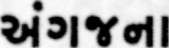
અંગજના
